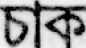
চাক
